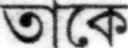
তাকে
